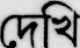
দেখি
